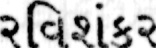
રવિશંકર
